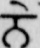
ਨੇ
